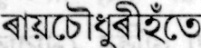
ৰায়চৌধুৰীহঁতে
